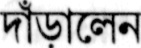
দাঁড়ালেন
